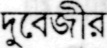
দুবেজীর
